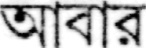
আবার
